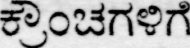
ಕ್ರೌಂಚಗಳಿಗೆ
